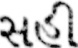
સહી
